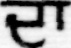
ਦਾ
